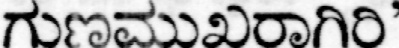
ಗುಣಮುಖರಾಗಿರಿ
